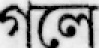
গলে
